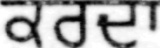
ਕਰਦਾ
